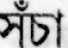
সঁচা
